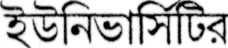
ইউনিভার্সিটির
